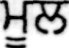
ਮੂਲ
